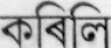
কৰিলি
